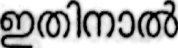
ഇതിനാല്‍
